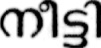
നീട്ടി
